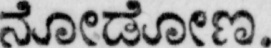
ನೋಡೋಣ.
